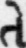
તે
